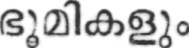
ഭൂമികളും
